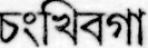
চংখিবগা
